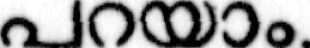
പറയാം.
